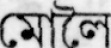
মোলৈ
